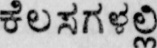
ಕೆಲಸಗಳಲ್ಲಿ
